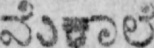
ಮೆಕಾಲೆ
